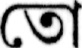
তো
